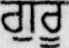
ਗੁਰੂ
